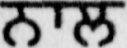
ਨਾਲ
